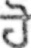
ਹੋ
